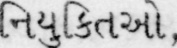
નિયુક્તિઓ,
